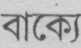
বাক্যে
